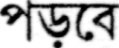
পড়বে
